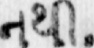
નથી.
